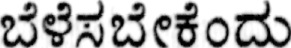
ಬೆಳೆಸಬೇಕೆಂದು
